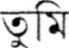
তুমি
